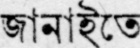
জানাইতে
